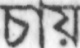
চায়
